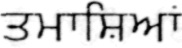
ਤਮਾਸ਼ਿਆਂ
